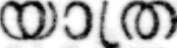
യാത്ര
